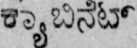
ಕ್ಯಾಬಿನೆಟ್
